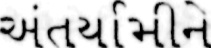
અંતર્યામીને
